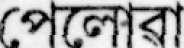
পেলোৱা
